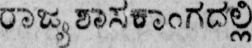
ರಾಜ್ಯಶಾಸಕಾಂಗದಲ್ಲಿ
